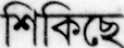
শিকিছে
